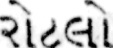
રોટલો
